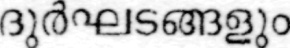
ദുര്‍ഘടങ്ങളും
